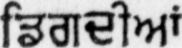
ਡਿਗਦੀਆਂ
